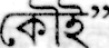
কৌই”
